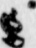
હું
